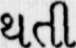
થતી
